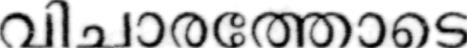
വിചാരത്തോടെ
